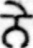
ਨੇ
